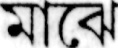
মাঝে
